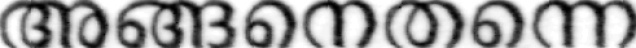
അങ്ങനെതന്നെ
